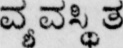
ವ್ಯವಸ್ಥಿತ
